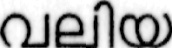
വലിയ
